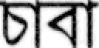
চাবা
